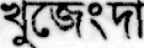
খুজেংদা
